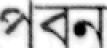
পবন
